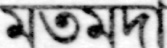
মতমদা
